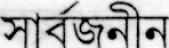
সার্বজনীন
